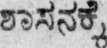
ಶಾಸನಕ್ಕೆ
